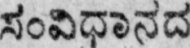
ಸಂವಿಧಾನದ
